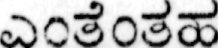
ಎಂತೆಂತಹ
